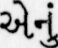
એનું
